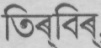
তিৰ্‌বিৰ্‌,
